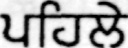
ਪਹਿਲੇ
